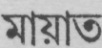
মায়াত
